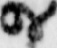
જ
